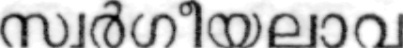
സ്വര്‍ഗീയലാവ
